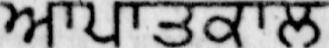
ਆਪਾਤਕਾਲ
